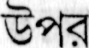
উপর
